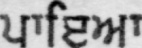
ਪਾਇਆ
